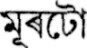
মূৰটো
